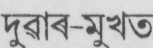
দুৱাৰ-মুখত
